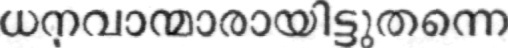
ധനവാന്മാരായിട്ടുതന്നെ
